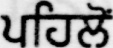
ਪਹਿਲੋਂ
